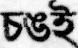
চঙই
